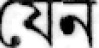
যেন
